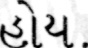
હોય.
